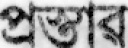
প্রস্তাৱ
